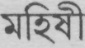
মহিষী
